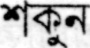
শকুন
